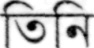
তিনি
